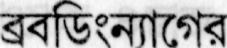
ব্রবডিংন্যাগের
